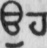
ਉਹ
